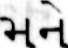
મને
